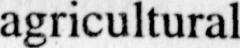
agricultural
